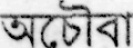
অচৌবা
